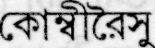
কোম্বীরৈসু
